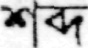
শব্দ
